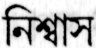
নিশ্বাস
